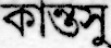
কান্তসু
